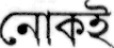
নোকই
